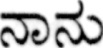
ನಾನು
